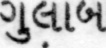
ગુલાબ
